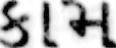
કામ
